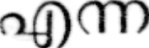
എന്ന
